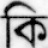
কি
